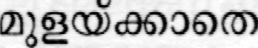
മുളയ്ക്കാതെ
